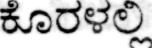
ಕೊರಳಲ್ಲಿ
